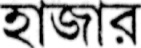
হাজার
